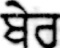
ਬੇਰ
